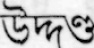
উদ্দন্ড
